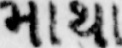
માથા
